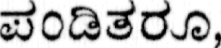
ಪಂಡಿತರೂ,
